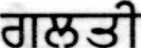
ਗਲਤੀ
